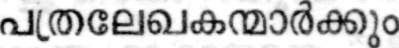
പത്രലേഖകന്മാര്‍ക്കും
